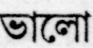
ভালো
